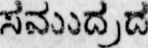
ಸಮುದ್ರದ
